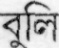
বুলি
